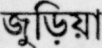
জুড়িয়া
